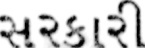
સરકારી
